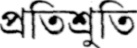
প্রতিশ্রুতি
